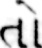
તો
